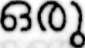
ഒരു
